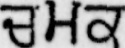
ਚਮਕ
